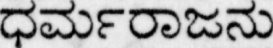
ಧರ್ಮರಾಜನು
